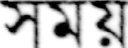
সময়
